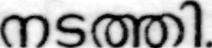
നടത്തി.
